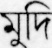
মুদি
